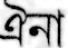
ঐনা
